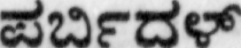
ಪರ್ಬಿದಳ್
